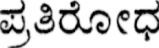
ಪ್ರತಿರೋಧ
